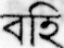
বহি
